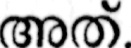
അത്.
